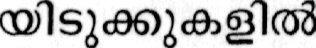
യിടുക്കുകളില്‍
